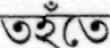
তহঁতে
